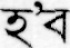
হ'ব
